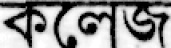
কলেজ
